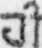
ਹੀ
